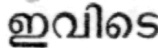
ഇവിടെ
